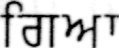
ਗਿਆ
